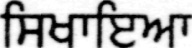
ਸਿਖਾਇਆ
